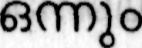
ഒന്നും
